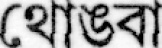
থোঙবা
